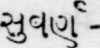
સુવર્ણ-
